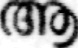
ആ
